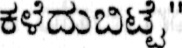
ಕಳೆದುಬಿಟ್ಟೆ”
